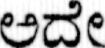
ಅದೇ
